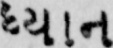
ધ્યાન
